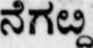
ನೆಗೞ್ದ
